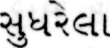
સુધરેલા
